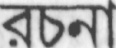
রচনা
